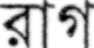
রাগ
